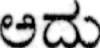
ಅದು
